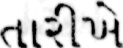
તારીખે
